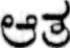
ಆತ
